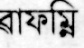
ৱাফম্নি
